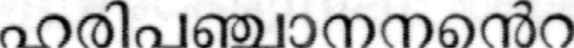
ഹരിപഞ്ചാനനന്റെ
